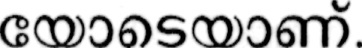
യോടെയാണ്.
